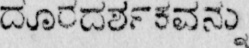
ದೂರದರ್ಶಕವನ್ನು
